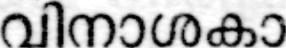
വിനാശകാ
